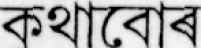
কথাবোৰ
